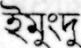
ইমুংদু
